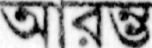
আরম্ভ
